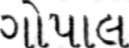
ગોપાલ
